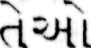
તેઓ
